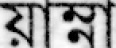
য়াম্না
